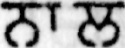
ਨਾਲ
